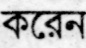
করেন
